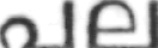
പല
